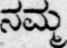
ನಮ್ಮ
